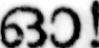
ഓ!
